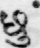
છું
